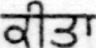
ਕੀਤਾ
